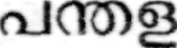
പന്തള
